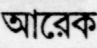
আরেক
